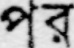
পর
